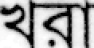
খরা
